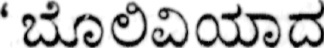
'ಬೊಲಿವಿಯಾದ
